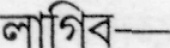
লাগিব-
